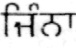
ਜਿੰਨਾ
